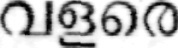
വളരെ
